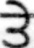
ਤੇ
